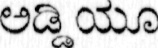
ಅಡ್ಡಿಯೂ
